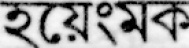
হয়েংমক
